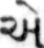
એ
